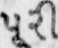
પૂરી
